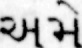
અમે
